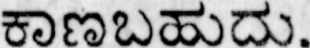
ಕಾಣಬಹುದು.
